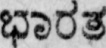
ಭಾರತ
